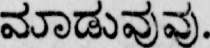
ಮಾಡುವುವು.
